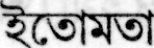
ইতোমতা
